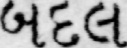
બદલ
